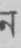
ন
